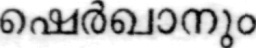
ഷെര്‍ഖാനും
